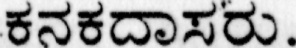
ಕನಕದಾಸರು.
